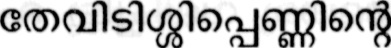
തേവിടിശ്ശിപ്പെണ്ണിന്റെ
